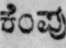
ಕೆಂಪು
